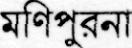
মণিপুরদা
